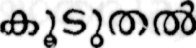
കൂടുതല്‍
